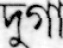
দুগা
